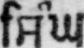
ਸਿੰਘ
